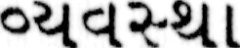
વ્યવસ્થા
